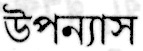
উপন্যাস
